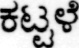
ಕಟ್ಟಳೆ
